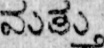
ಮತ್ತು
